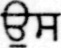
ਉਸ
